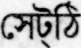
সেট্ঠি
